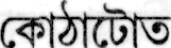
কোঠাটোত
